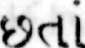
છતાં
